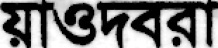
য়াওদবরা
